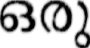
ഒരു
